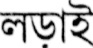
লড়াই
